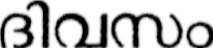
ദിവസം
